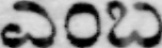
ಎಂಬ
